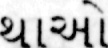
થાઓ
